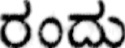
ರಂದು
